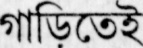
গাড়িতেই
